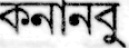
কনানবু
